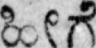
ಹೀಗೆ
